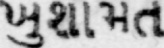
ખુશામત
